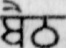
ਬੈਠ
